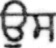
ਉਸ
